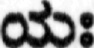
ಯಃ
